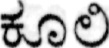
ಕೂಲಿ
